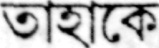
তাহাকে
